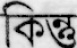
কিন্তু
